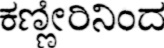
ಕಣ್ಣೀರಿನಿಂದ
